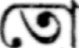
তো
